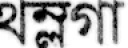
থম্লগা
